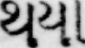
થયા
